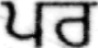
ਪਰ
